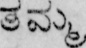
ತಮ್ಮ
